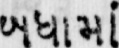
બધામાં
